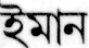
ইমান
